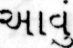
આવું
